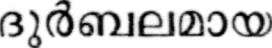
ദുര്‍ബലമായ
